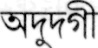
অদুদগী
